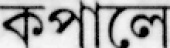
কপালে
